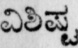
ವಿಶಿಷ್ಟ
